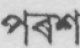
পৰশ
